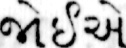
જોઈએ
